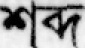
শব্দ
